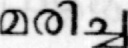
മരിച്ച
